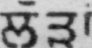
ਲੋੜਾਂ
